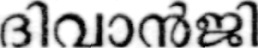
ദിവാന്‍ജി
